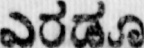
ಎರಡೂ
